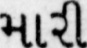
મારી
